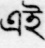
এই
